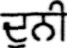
ਦੁਨੀ
